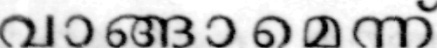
വാങ്ങാമെന്ന്
